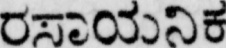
ರಸಾಯನಿಕ
